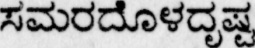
ಸಮರದೊಳದೃಷ್ಟ
